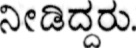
ನೀಡಿದ್ದರು.
